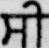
ਸੀ
